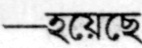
–হয়েছে
